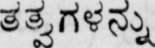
ತತ್ವಗಳನ್ನು
